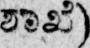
ಶಾಖೆ)
